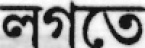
লগতে
